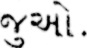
જુઓ.
